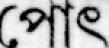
পোৎ
